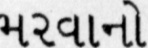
મરવાનો
